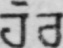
ਹੋਰ
